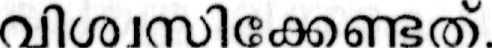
വിശ്വസിക്കേണ്ടത്.
